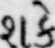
શકે
